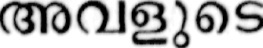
അവളുടെ
